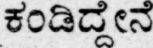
ಕಂಡಿದ್ದೇನೆ
